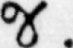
જ.
